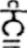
ਨੂੰ
